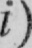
i)
